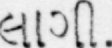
લાગી.
